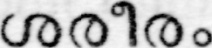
ശരീരം
